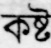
কষ্ট
